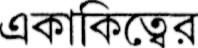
একাকিত্বের
